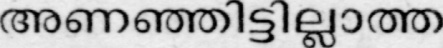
അണഞ്ഞിട്ടില്ലാത്ത
